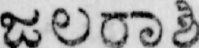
ಜಲರಾಶಿ
